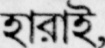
হারাই,
